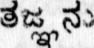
ತಜ್ಞನು
